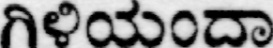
ಗಿಳಿಯಂದಾ
